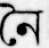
নৈ
